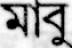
মাবু
